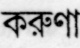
করুণা
